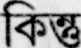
কিন্তু
